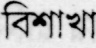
বিশাখা
